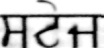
ਸਟੇਜ
